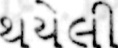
થયેલી
